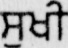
ਸੁਖੀ
